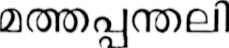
മത്തപ്പന്തലി
